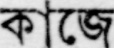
কাজে
